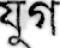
যুগ
